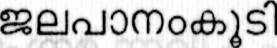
ജലപാനംകൂടി
